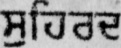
ਸੁਹਿਰਦ
